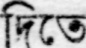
দিতে
